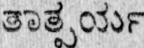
ತಾತ್ಪರ್ಯ
